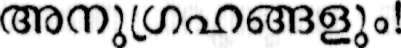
അനുഗ്രഹങ്ങളും!
